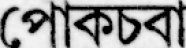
পোকচবা
